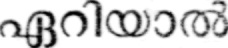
ഏറിയാല്‍
